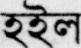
হইল
